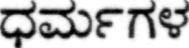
ಧರ್ಮಗಳ
